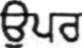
ਉਪਰ
